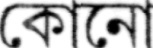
কোনো
